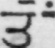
ਤੋਂ
